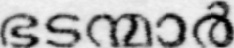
ഭടന്മാര്‍
